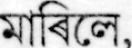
মাৰিলে,
